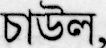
চাউল,
